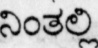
ನಿಂತಲ್ಲಿ
